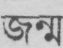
জন্ম
